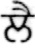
ਲੈ
